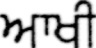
ਆਖੀ
